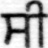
ਸੀ
